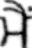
ਮੈਂ
